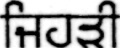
ਜਿਹੜੀ
